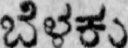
ಬೆಳಕು
